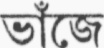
ভাঁজে
